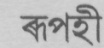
ৰূপহী
